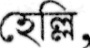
হেল্লি,
